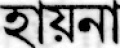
হায়না
